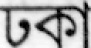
ঢকা
